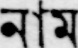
নাম
